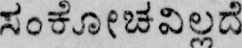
ಸಂಕೋಚವಿಲ್ಲದೆ
